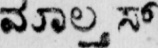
ಮಾಲ್ತಸ್
